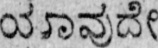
ಯಾವುದೇ
